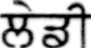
ਲੇਡੀ
